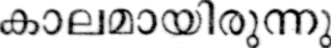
കാലമായിരുന്നു
